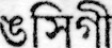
ঙসিগী
